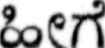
ಹೀಗೆ
